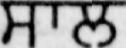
ਸਾਲ
